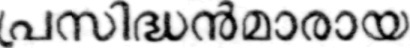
പ്രസിദ്ധന്‍മാരായ
